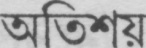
অতিশয়
